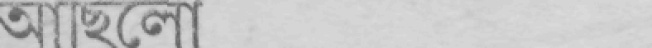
আছলো
